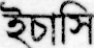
ইচাসি
